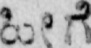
ಹೀಗೆ
